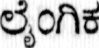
ಲೈಂಗಿಕ
